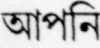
আপনি
